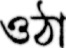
ওঠা
